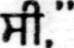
ਸੀ,''
